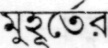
মুহূর্তের
